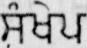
ਸੰਖੇਪ
